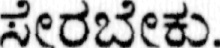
ಸೇರಬೇಕು.
